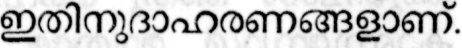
ഇതിനുദാഹരണങ്ങളാണ്.
